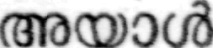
അയാള്‍
